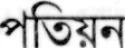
পতিয়ন
